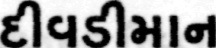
દીવડીમાન
